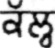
ਕੱਲ੍ਹ
